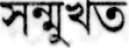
সন্মুখত
